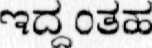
ಇದ್ದಂತಹ
